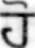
ਹੋ
